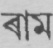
ৰাম
